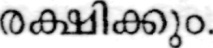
രക്ഷിക്കും.
